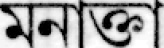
মনাক্তা
